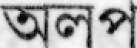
অলপ
